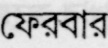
ফেরবার
